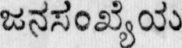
ಜನಸಂಖ್ಯೆಯ
